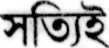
সত্যিই
